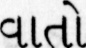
વાતો
